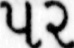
પર
